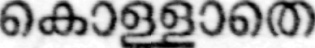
കൊള്ളാതെ
